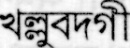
খল্লুবদগী
